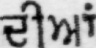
ਦੀਆਂ
